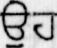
ਉਹ
